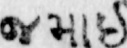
જમાઈ
